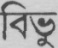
বিভু
